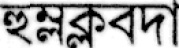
হুম্লক্লবদা
